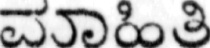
ಮಾಹಿತಿ
